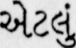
એટલું
